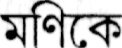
মণিকে
